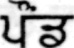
ਪੌਂਡ
